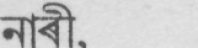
নাৰী,
